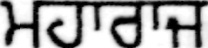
ਮਹਾਰਾਜ
